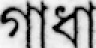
গাধা
